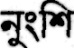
নুংশি
